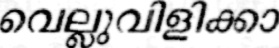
വെല്ലുവിളിക്കാ
